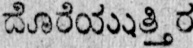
ದೊರೆಯುತ್ತಿರ
